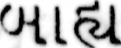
બાહ્ય
